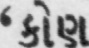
'કોણ
